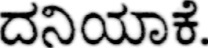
ದನಿಯಾಕೆ.
